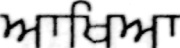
ਆਖਿਆ
